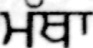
ਮੱਥਾ
